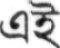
এই
